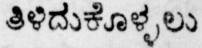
ತಿಳಿದುಕೊಳ್ಳಲು
